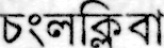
চংলক্লিবা
